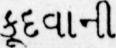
કૂદવાની
